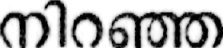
നിറഞ്ഞ
